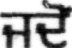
ਜਦੋਂ
